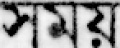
সময়
